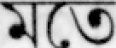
মতে
